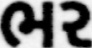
ભર
